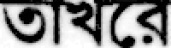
তাখরে
